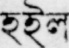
হইল
